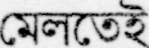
মেলতেই
